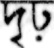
দৃঢ়
